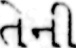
તેની
